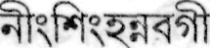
নীংশিংহন্নবগী
